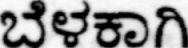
ಬೆಳಕಾಗಿ
